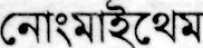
নোংমাইথেম
